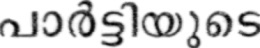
പാര്‍ട്ടിയുടെ
